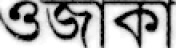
ওজাকা
